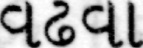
વઢવા
